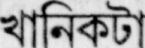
খানিকটা
